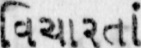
વિચારતાં
